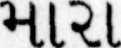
મારા
